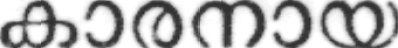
കാരനായ
